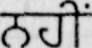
ਨਹੀਂ
